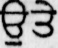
ਉਤੇ
